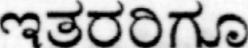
ಇತರರಿಗೂ
